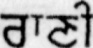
ਰਾਣੀ
